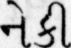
નેકી
